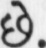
છે.
